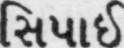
સિપાઈ
